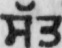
ਸੱਤ
